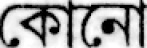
কোনো
